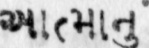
આત્માનું
